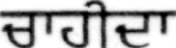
ਚਾਹੀਦਾ
